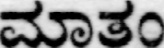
ಮಾತ೦
